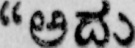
“ಅದು
